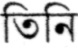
তিনি
